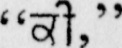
''ਕੀ,''
